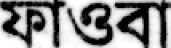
ফাওবা
